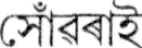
সোঁৱৰাই
